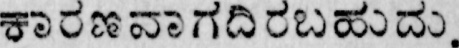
ಕಾರಣವಾಗದಿರಬಹುದು,
